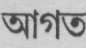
আগত
